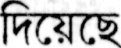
দিয়েছে
